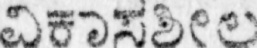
ವಿಕಾಸಶೀಲ
